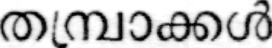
തമ്പ്രാക്കള്‍
